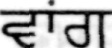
ਵਾਂਗ
